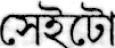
সেইটো
